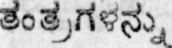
ತಂತ್ರಗಳನ್ನು
